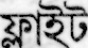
ফ্লাইট
